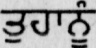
ਤੁਹਾਨੂੰ
